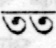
তত
